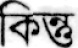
কিন্তু
